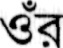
ওঁর
